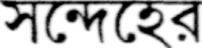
সন্দেহের
